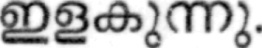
ഇളകുന്നു.
